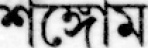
শঙ্গোম
